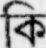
কি
